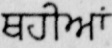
ਥਹੀਆਂ
